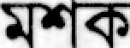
মশক
